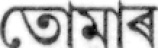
তোমাৰ
